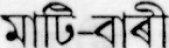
মাটি-বাৰী
